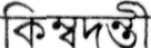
কিম্বদন্তী
